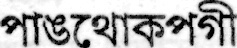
পাঙথোকপগী
